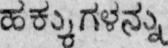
ಹಕ್ಕುಗಳನ್ನು
